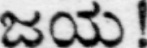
ಜಯ!
